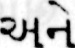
અને
